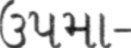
ઉપમા-
